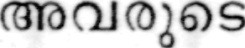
അവരുടെ
